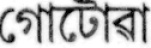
গোটোৱা
